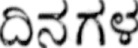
ದಿನಗಳ
